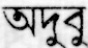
অদুবু
